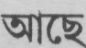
আছে
